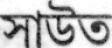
সাউত
